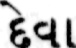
દેવા
